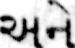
અને
